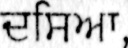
ਦਸਿਆ,
